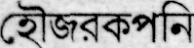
হৌজরকপনি
